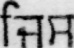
ਜਿਸ
